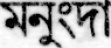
মনুংদা
